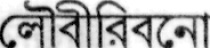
লৌবীরিবনো
